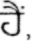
ਹੈਂ,
